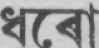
ধৰো
